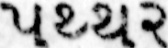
પથ્થર
